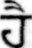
ਹੈ
